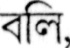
বলি,
